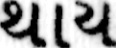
થાય
